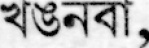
খঙনবা,
